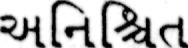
અનિશ્ચિત
